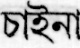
চাইনা
